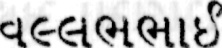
વલ્લભભાઈ
